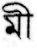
মী
